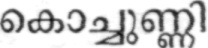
കൊച്ചുണ്ണി
